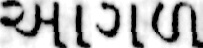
આગળ
